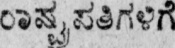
ರಾಷ್ಟ್ರಪತಿಗಳಿಗೆ
